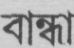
বান্ধা
